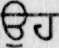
ਉਹ
